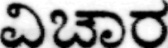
ವಿಚಾರ
